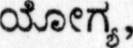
ಯೋಗ್ಯ,
